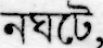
নঘটে,
